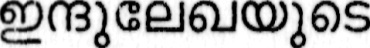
ഇന്ദുലേഖയുടെ
